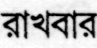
রাখবার
